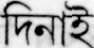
দিনাই
